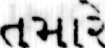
તમારે
